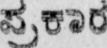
ಪ್ರಕಾರ
